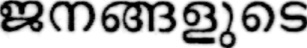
ജനങ്ങളുടെ
